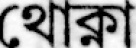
থোক্না
